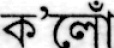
ক'লোঁ
